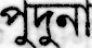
পুদুনা
